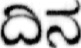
ದಿನ
